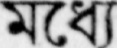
মধ্যে
